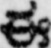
ಈ
